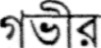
গভীর
